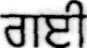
ਗਈ
